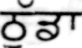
ਠੁੱਡਾ
